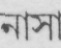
নাসা
